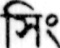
সিং
